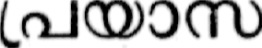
പ്രയാസ
